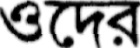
ওদের
